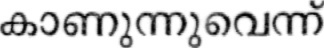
കാണുന്നുവെന്ന്
